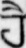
ਹੈ
